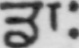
ਡਾ:
